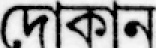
দোকান
